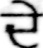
ਦੇ
